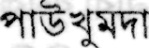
পাউখুমদা
